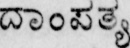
ದಾಂಪತ್ಯ
